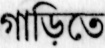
গাড়িতে
